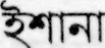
ইশানা
